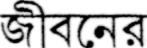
জীবনের
